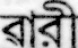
ৱারী
